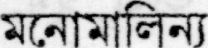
মনোমালিন্য
